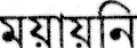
ময়ায়নি
